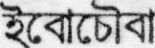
ইবোচৌবা
